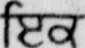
ਇਕ
